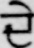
ਦੇ
